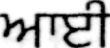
ਆਈ
